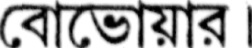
বোভোয়ার।
